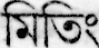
মিতিং
